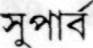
সুপার্ব
